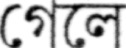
গেলে
